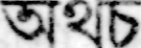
অথচ
